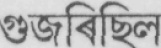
গুজৰিছিল
